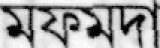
মফমদা
